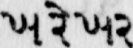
ખરેખર
